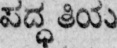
ಪದ್ಧತಿಯ
